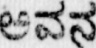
ಅವನ
